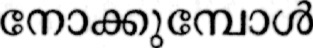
നോക്കുമ്പോള്‍
